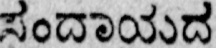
ಸಂದಾಯದ
